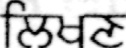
ਲਿਖਣ
